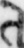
તે
